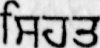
ਸਿਹਤ
